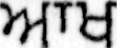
ਆਖ
